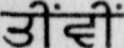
ਤੀਂਵੀਂ
